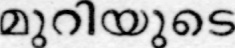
മുറിയുടെ
